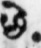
છે.
